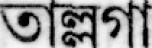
তাল্লগা
